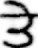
ਤੇ
